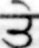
ਤੇ
